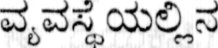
ವ್ಯವಸ್ಥೆಯಲ್ಲಿನ
